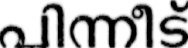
പിന്നീട്
